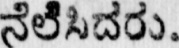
ನೆಲೆಸಿದರು.
